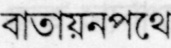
বাতায়নপথে
